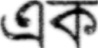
এক
